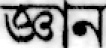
জ্ঞান
